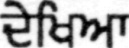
ਦੇਖਿਆ
